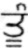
ਤੂੰ
